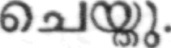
ചെയ്തു.
